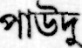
পাউদু
